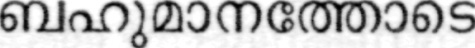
ബഹുമാനത്തോടെ
